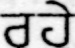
ਰਹੇ
